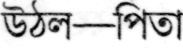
উঠল–পিতা
